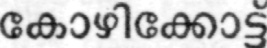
കോഴിക്കോട്ട്
